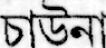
চাউনা
